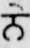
ਨੇ
